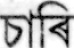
চাৰি
